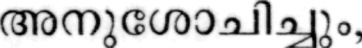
അനുശോചിച്ചും,
